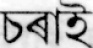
চৰাই
